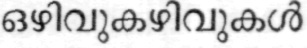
ഒഴിവുകഴിവുകള്‍
